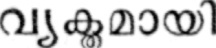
വ്യക്തമായി
